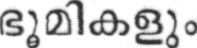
ഭൂമികളും
